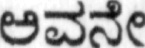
ಅವನೇ
